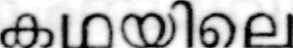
കഥയിലെ
